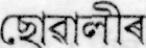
ছোৱালীৰ
